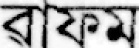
ৱাফম
